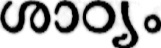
ശാഠ്യം
